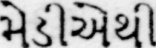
મેડીએથી
